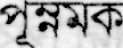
পূম্নমক
